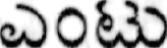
ಎಂಟು
